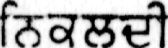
ਨਿਕਲਦੀ
